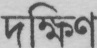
দক্ষিণ
